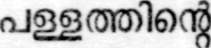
പള്ളത്തിന്റെ
